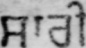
ਸਾਰੀ
